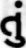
તું
